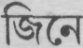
জিনে
